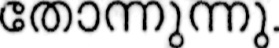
തോന്നുന്നു.
